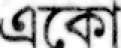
একো
